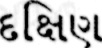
દક્ષિણ
